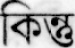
কিন্তু
